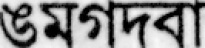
ঙমগদবা
